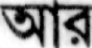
আর
